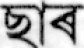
ছাৰ
